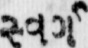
સ્વર્ગ
